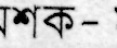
মশক-
